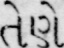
તેણે
